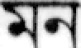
মন
